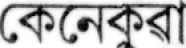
কেনেকুৱা
